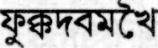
ফুক্কদবমখৈ
